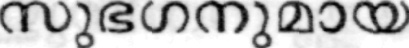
സുഭഗനുമായ
